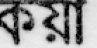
কয়া
